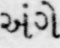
અંગે
